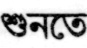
শুনতে
